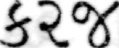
કરજ
